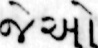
જેઓ
